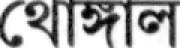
থোঙ্গাল
